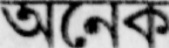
অনেক
